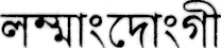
লান্থোরক্তুনা
